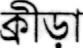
ক্রীড়া
